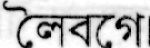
লৈবগে।
